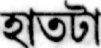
হাতটা
